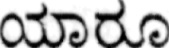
ಯಾರೂ
